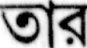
তার
